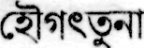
হৌগৎতুনা
